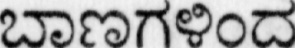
ಬಾಣಗಳಿಂದ
